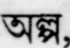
অল্প,
